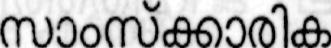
സാംസ്ക്കാരിക
